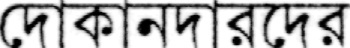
দোকানদারদের
